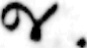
જ.
